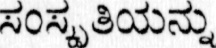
ಸಂಸ್ಕೃತಿಯನ್ನು
